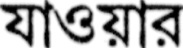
যাওয়ার
